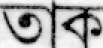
তাক
